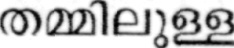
തമ്മിലുള്ള
